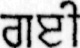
ਗਈ
